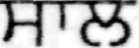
ਸਾਲ
